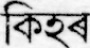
কিহৰ
